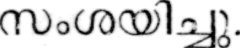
സംശയിച്ചു.
